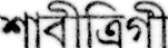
শাবীত্রিগী
